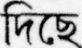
দিছে
